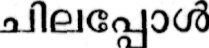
ചിലപ്പോള്‍
